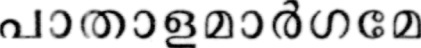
പാതാളമാര്‍ഗമേ
